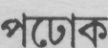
পঢ়োক
